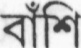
বাঁশি
